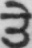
ਤੇ
